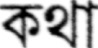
কথা
